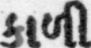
કાળી
